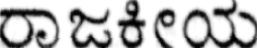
ರಾಜಕೀಯ
